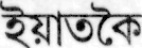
ইয়াতকৈ
